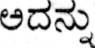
ಅದನ್ನು
